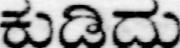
ಕುಡಿದು
